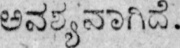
ಅವಶ್ಯವಾಗಿದೆ.
